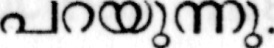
പറയുന്നു.
